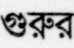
গুরুর
